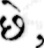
છે,
